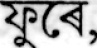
ফুৰে,
